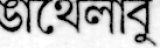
ঙাথেলাবু
